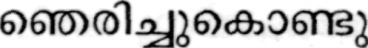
ഞെരിച്ചുകൊണ്ടു
